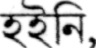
হইনি,
